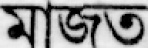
মাজত
